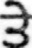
ਤੇ
